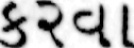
કરવા
